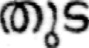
തുട
